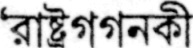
‘রাষ্ট্রগগনকী
